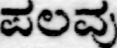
ಪಲವು
